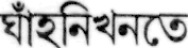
ঘাঁহনিখনতে
